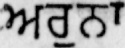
ਅਰੁਨਾ
